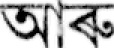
আৰু
